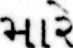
મારે
